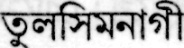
তুলসিমনাগী
